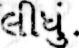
લીધું.
